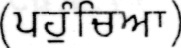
(ਪਹੁੰਚਿਆ)
